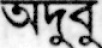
অদুবু
